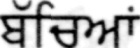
ਬੱਚਿਆਂ
